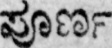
ಪೂರ್ಣ
